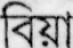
বিয়া
